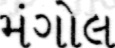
મંગોલ
